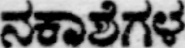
ನಕಾಶೆಗಳ
